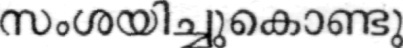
സംശയിച്ചുകൊണ്ടു
